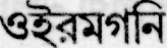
ওইরমগনি
